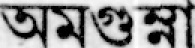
অমগুম্না
